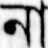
না
